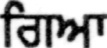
ਗਿਆ
